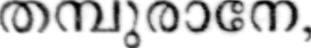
തമ്പുരാനേ,
